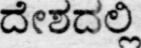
ದೇಶದಲ್ಲಿ
